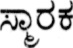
ಸ್ಮಾರಕ
